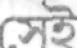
সেই
